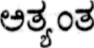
ಅತ್ಯಂತ
